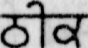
ਠੀਕ
